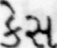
કેસ
